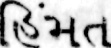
હિંમત
